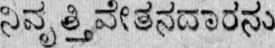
ನಿವೃತ್ತಿವೇತನದಾರನು
